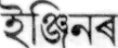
ইঞ্জিনৰ
